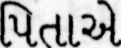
પિતાએ
